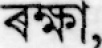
ৰক্ষা,
